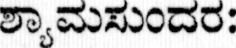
ಶ್ಯಾಮಸುಂದರ:
